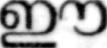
ഈ
